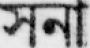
সনা
